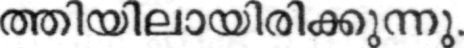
ത്തിയിലായിരിക്കുന്നു.
